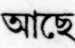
আছে
